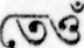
তেওঁ
